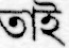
তাই
